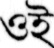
ওই
